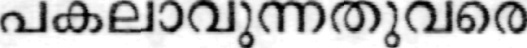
പകലാവുന്നതുവരെ
